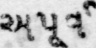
અપૂર્વ
